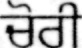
ਚੋਰੀ
